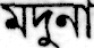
মদুদা
